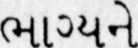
ભાગ્યને
